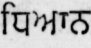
ਧਿਆਨ
